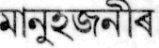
মানুহজনীৰ
